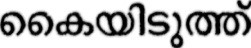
കൈയിടുത്ത്
